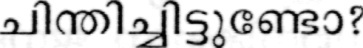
ചിന്തിച്ചിട്ടുണ്ടോ?
